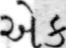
એક
